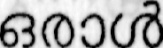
ഒരാള്‍
